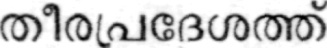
തീരപ്രദേശത്ത്
